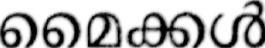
മൈക്കള്‍
